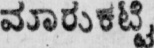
ಮಾರುಕಟ್ಟೆ
